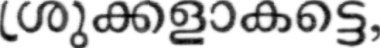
ശ്രുക്കളാകട്ടെ,
